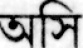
অসি
